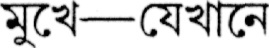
মুখে-যেখানে
